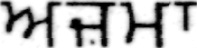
ਅਜ਼ਮਾ
